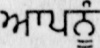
ਆਪਨੂੰ
